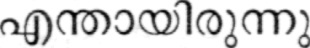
എന്തായിരുന്നു
